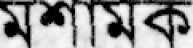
মশামক
